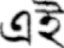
এই
